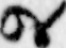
જ
